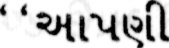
"આપણી
